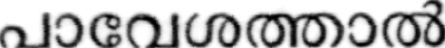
പാവേശത്താല്‍
